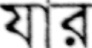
যার
